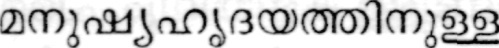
മനുഷ്യഹൃദയത്തിനുള്ള
